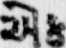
એક
